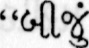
"બીજું
